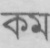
কম
